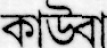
কাউবা
